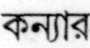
কন্যার
